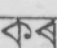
কৰ
